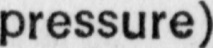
Pressure)
